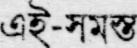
এই-সমস্ত
